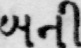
બની
